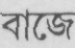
বাজে
